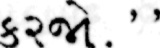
કરજો."
